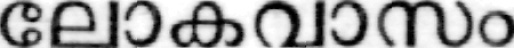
ലോകവാസം
